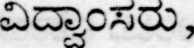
ವಿದ್ವಾಂಸರು,
